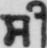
ਸੀ
